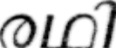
രഥി
